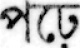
পঢ়ে
